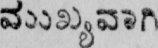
ಮುಖ್ಯವಾಗಿ
